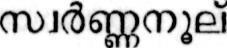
സ്വര്‍ണ്ണനൂല്
